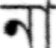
না
